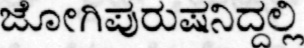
ಜೋಗಿಪುರುಷನಿದ್ದಲ್ಲಿ
